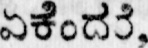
ಏಕೆಂದರೆ,
